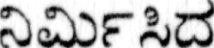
ನಿರ್ಮಿಸಿದ
